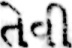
તેવી
